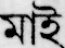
মাই
